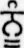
ਨੂੰ
